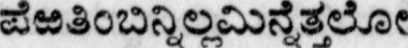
ಪೆಱತಿಬಂನ್ನಿಲ್ಲಮಿನ್ನೆತ್ತಲೋ
